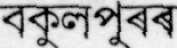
বকুলপুৰৰ
